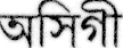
অসিগী
